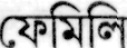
ফেমিলি
